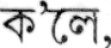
ক'লে,
